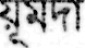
য়ূমদা
